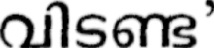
വിടണ്ട’
